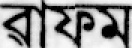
ৱাফম
